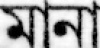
মানা
